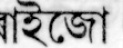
ৰাইজো
